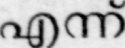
എന്ന്
